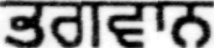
ਭਗਵਾਨ
